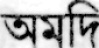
অমদি
